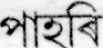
পাহৰি
